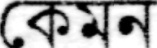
কেমন
